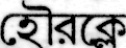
হৌরক্লে
